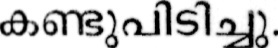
കണ്ടുപിടിച്ചു.
